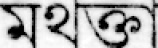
মথক্তা
